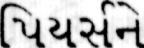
પિયર્સને
